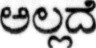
ಅಲ್ಲದೆ
